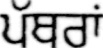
ਪੱਥਰਾਂ
